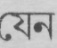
যেন
